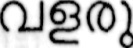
വളരു
